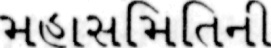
મહાસમિતિની
